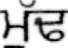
ਮੁੱਢ
